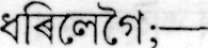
ধৰিলেগৈ;-
